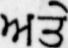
ਅਤੇ
